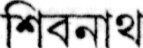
শিবনাথ
